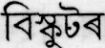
বিস্কুটৰ
